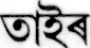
তাইৰ
